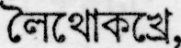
লৈথোকখ্রে,
